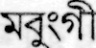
মবুংগী
